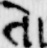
તો
